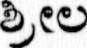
ಶ್ರೀಲ
